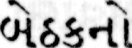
બેઠકનો
